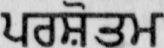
ਪਰਸ਼ੋਤਮ
